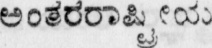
ಅಂತರರಾಷ್ಟ್ರೀಯ
